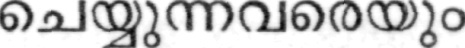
ചെയ്യുന്നവരെയും
